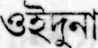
ওইদুনা
